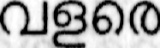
വളരെ
